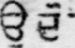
ਉਦੋਂ
